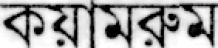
কয়ামরুম
